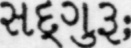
સદગુરૂ;
